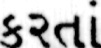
કરતાં
